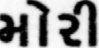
મોરી
